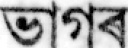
ভাগৰ
